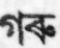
গৰু
